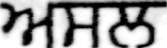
ਅਸਲ
